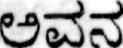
ಅವನ
